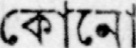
কোনো
